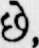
છે,
